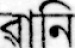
ৱানি
